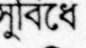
সুবিধে
